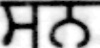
ਸਨ
